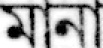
মানা
